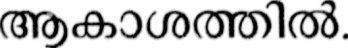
ആകാശത്തില്‍.
